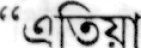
"এতিয়া
